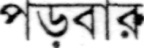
পড়বার
